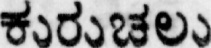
ಕುರುಚಲು
